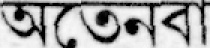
অতেনবা
